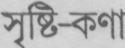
সৃষ্টি-কণা
